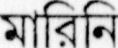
মারিনি
